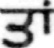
ਤਾਂ
